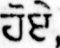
ਹੋਏ,
